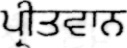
ਪ੍ਰੀਤਵਾਨ
